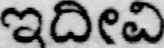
ಇದೀವಿ
